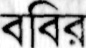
ববির
